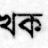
খক
